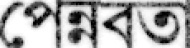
পেন্নবতা
